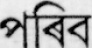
পৰিব
